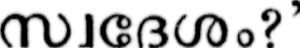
സ്വദേശം?’
